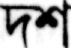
দশ
